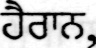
ਹੈਰਾਨ,
